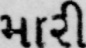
મારી
